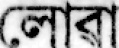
লোৱা
